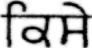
ਕਿਸੇ
